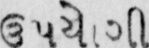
ઉપયોગી
